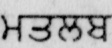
ਮਤਲਬ
